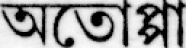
অতোপ্পা
